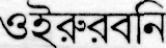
ওইরুরবনি
